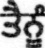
ਤੈਨੂੰ
